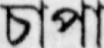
চাপা
